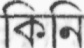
কিনি
